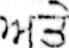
ਅਤੇ
